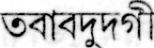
তবাবদুদগী
